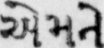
એમને
